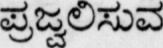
ಪ್ರಜ್ವಲಿಸುವ
